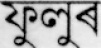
ফুলুৰ
